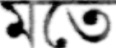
মতে
